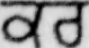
ਕਰ
